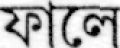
ফালে
